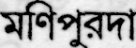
মণিপুরদা
